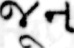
જૂન
